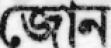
জোন
